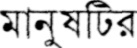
মানুষটির
